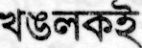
খঙলকই
